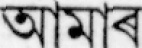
আমাৰ
